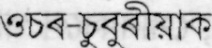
ওচৰ-চুবুৰীয়াক
